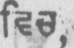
ਵਿਚ,
